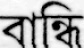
বান্ধি
